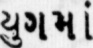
યુગમાં
